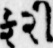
ફરી
